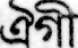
ঐগী
